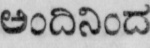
ಅಂದಿನಿಂದ
